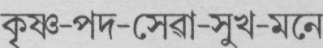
কৃষ্ণ-পদ-সেৱা-সুখ-মনে
